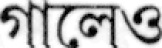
গালেও
